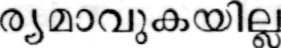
ര്യമാവുകയില്ല
